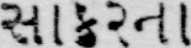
સાકરના
